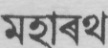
মহাৰথ
